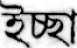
ইচ্ছা
